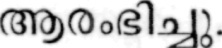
ആരംഭിച്ചു.
